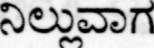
ನಿಲ್ಲುವಾಗ
